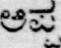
ಅಪ್ಪ
